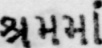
શ્રમમાં
